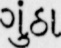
ગુંઠા
